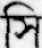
সি
